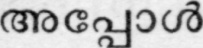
അപ്പോള്‍
